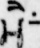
ਮੈਂ
